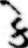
કે
